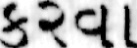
કરવા
